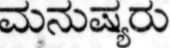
ಮನುಷ್ಯರು
